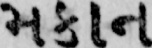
મકાન
